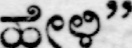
ಹೇಳಿ"
